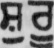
ਸ਼ੁਰੂ
